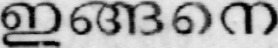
ഇങ്ങനെ
